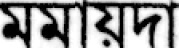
মমায়দা
